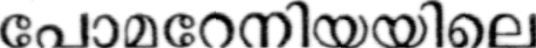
പോമറേനിയയിലെ
